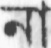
না
